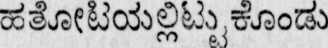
ಹತೋಟಿಯಲ್ಲಿಟ್ಟುಕೊಂಡು
